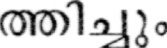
ത്തിച്ചും
